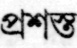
প্রশস্ত
